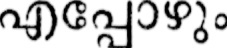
എപ്പോഴും
